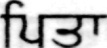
ਪਿਤਾ
